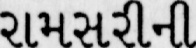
રામસરીની
